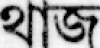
থাজ
